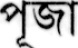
পূজা
